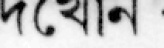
দখোন
